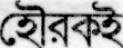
হৌরকই
